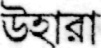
উহারা
